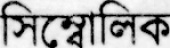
সিম্বোলিক
